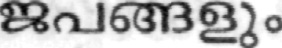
ജപങ്ങളും
